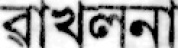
ৱাখলনা
